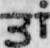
ਤਾਂ
